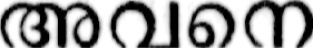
അവനെ
